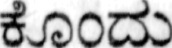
ಕೊಂದು
